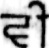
ਵੀ
